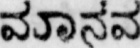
ಮಾನವ
